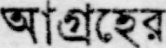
আগ্রহের
